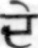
ਦੇ
